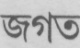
জগত
